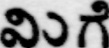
ಮಿಗೆ
